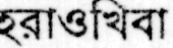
হরাওখিবা
